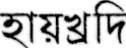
হায়খ্রদি
